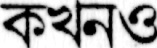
কখনও
